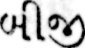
બીજી
